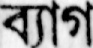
ব্যাগ
